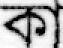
কা
